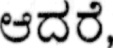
ಆದರೆ,
